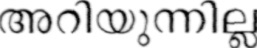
അറിയുന്നില്ല
